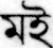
মই
